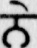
ਨੇ
